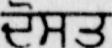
ਦੋਸਤ
